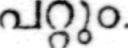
പറ്റും.
